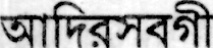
আদিরসবগী
